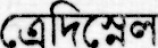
ত্রেদিস্নেল
